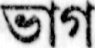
ভাগ
